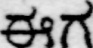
ಈಗ
